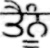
ਤੈਨੂੰ
